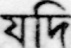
যদি
